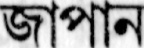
জাপান
